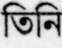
তিনি
